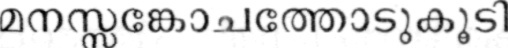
മനസ്സങ്കോചത്തോടുകൂടി
